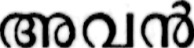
അവന്‍
